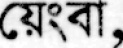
য়েংবা,
